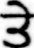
ਤੇ
